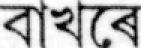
বাখৰে
